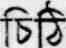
চিঠি
